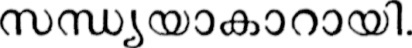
സന്ധ്യയാകാറായി.
